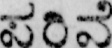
ಪರಿವೆ
